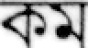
কম
